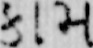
કામ
